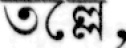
তল্লে,
